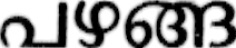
പഴങ്ങ
